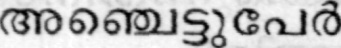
അഞ്ചെട്ടുപേര്‍
